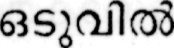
ഒടുവില്‍
